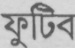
ফুটিব
